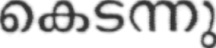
കെടന്നു
